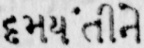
દમયંતીને
